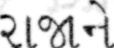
રાજાને
